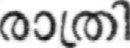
രാത്രി
